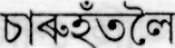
চাৰুহঁতলৈ
